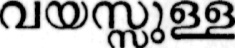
വയസ്സുള്ള
